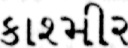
કાશ્મીર
